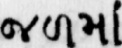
જળમાં
